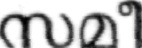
സമീ
